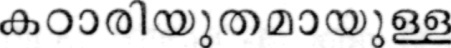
കഠാരിയുതമായുള്ള
